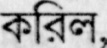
করিল,
